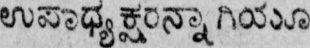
ಉಪಾಧ್ಯಕ್ಷರಾನ್ನಾಗಿಯೂ
